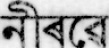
নীৰৱে
